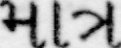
માત્ર
